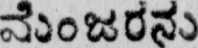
ಮೆಂಜರನು
